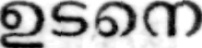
ഉടനെ
